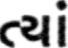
ત્યાં
